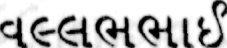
વલ્લભભાઈ
